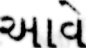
આવે
